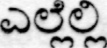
ಎಲ್ಲೆಲ್ಲಿ
